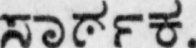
ಸಾರ್ಥಕ.
